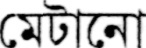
মেটানো
